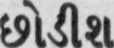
છોડીશ
